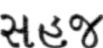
સહજ
